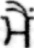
ਮੈਂ
